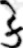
કે
